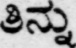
ತಿನ್ನು
